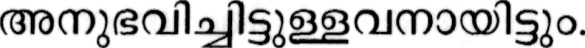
അനുഭവിച്ചിട്ടുള്ളവനായിട്ടും.
